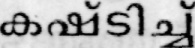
കഷ്ടിച്ച്
